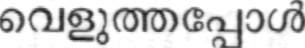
വെളുത്തപ്പോള്‍
